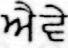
ਐਵੇ
